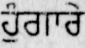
ਹੁੰਗਾਰੇ
